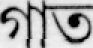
গাত
